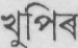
খুপিৰ
